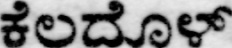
ಕೆಲದೊಳ್
